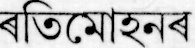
ৰতিমোহনৰ
